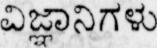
ವಿಜ್ಞಾನಿಗಳು
